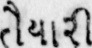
તૈયારી
